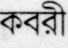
কবরী
